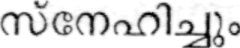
സ്നേഹിച്ചും
